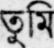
তুমি
